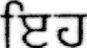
ਇਹ
